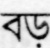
বড়
